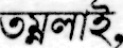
তম্নলাই,
